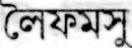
লৈফমসু
